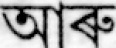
আৰু
